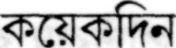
কয়েকদিন
